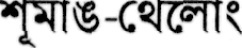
শূমাঙ-থেলোং
